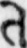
તે
